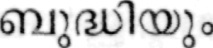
ബുദ്ധിയും
